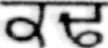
ਕਢ
